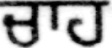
ਚਾਹ
